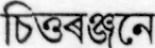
চিত্তৰঞ্জনে
